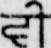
ਵੀ
